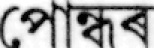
পোন্ধৰ
